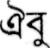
ঐবু
